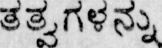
ತತ್ವಗಳನ್ನು
